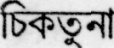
চিকতুনা
